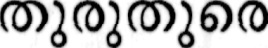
തുരുതുരെ
